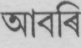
আবৰি
